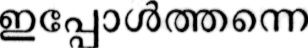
ഇപ്പോള്‍ത്തന്നെ
